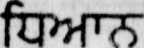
ਧਿਆਨ
